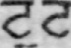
ਟੁਟ
